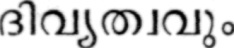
ദിവ്യത്വവും
